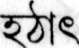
হঠাৎ
